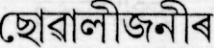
ছোৱালীজনীৰ
